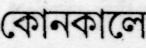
কোনকালে
